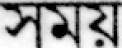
সময়
